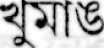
খুমাঙ
